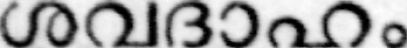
ശവദാഹം
